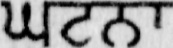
ਘਟਨਾ
